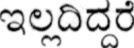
ಇಲ್ಲದಿದ್ದರೆ
